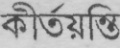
কীৰ্তয়ন্তি
